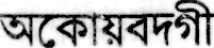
অকোয়বদগী
